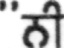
''ਨੀ
